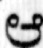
ಆ
